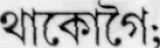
থাকোগৈ;
